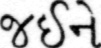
જઈને
